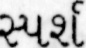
સ્પર્શ
